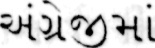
અંગ્રેજીમાં
